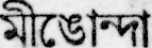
মীঙোন্দা
